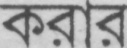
করার
